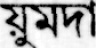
য়ুমদা
